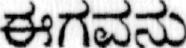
ಈಗವನು
